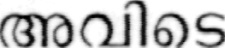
അവിടെ
